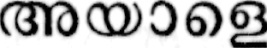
അയാളെ
